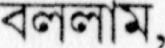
বললাম,
